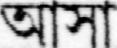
আসা
